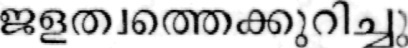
ജളത്വത്തെക്കുറിച്ചു
